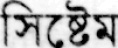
সিষ্টেম
